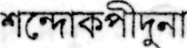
শন্দোকপীদুনা
